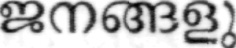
ജനങ്ങളു
